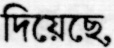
দিয়েছে,
